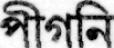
পীগনি
